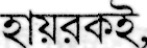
হায়রকই,
